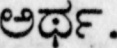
ಅರ್ಥ.
